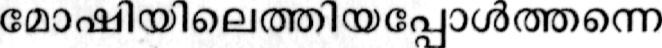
മോഷിയിലെത്തിയപ്പോള്‍ത്തന്നെ
